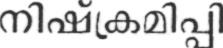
നിഷ്ക്രമിപ്പി
